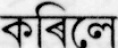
কৰিলে
